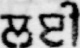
ਲਈ
